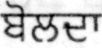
ਬੋਲਦਾ
